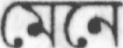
মেনে
